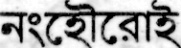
নংহৌরোই
